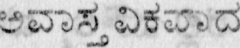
ಅವಾಸ್ತವಿಕವಾದ
